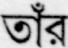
তাঁর
